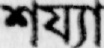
শয্যা
